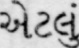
એટલું
